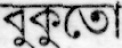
বুকুতো
